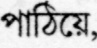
পাঠিয়ে,
